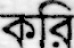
করি
